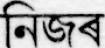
নিজৰ
